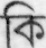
কি
